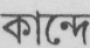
কান্দে
